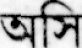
অসি
